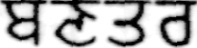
ਬਣਤਰ
